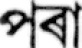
পৰা
